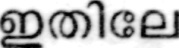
ഇതിലേ
